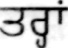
ਤਰ੍ਹਾਂ
